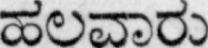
ಹಲವಾರು
